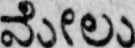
ಮೇಲು
